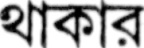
থাকার
